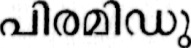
പിരമിഡു
